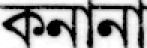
কনানা
